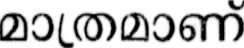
മാത്രമാണ്
